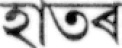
হাতৰ
